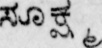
ಸೂಕ್ಷ್ಮ
